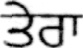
ਤੇਰਾ
